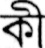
কী
